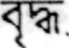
বৃদ্ধ
